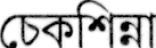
চেকশিন্না
